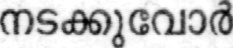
നടക്കുവോര്‍
